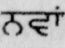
ਨਵਾਂ
